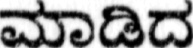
ಮಾಡಿದ
